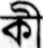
কী
